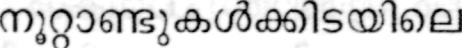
നൂറ്റാണ്ടുകള്‍ക്കിടയിലെ
